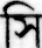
সি
